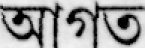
আগত
